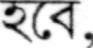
হবে,
